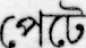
পেটে
